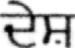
ਦੇਸ਼
